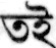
তই
